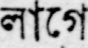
লাগে
